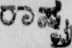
ರಾಷ್ಟ್ರ
